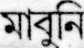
মাবুনি
